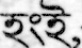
হংই,
